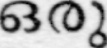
ഒരു
